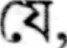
যে,
